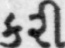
કરી
